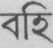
বহি
